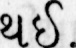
થઈ.
